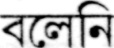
বলেনি
